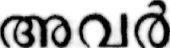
അവര്‍
